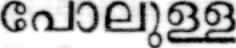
പോലുള്ള
